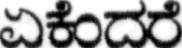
ಏಕೆಂದರೆ
